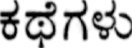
ಕಥೆಗಳು
